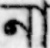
না
